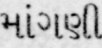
માંગણી
